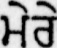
ਮੇਰੇ
